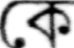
কে
